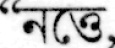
“নত্তে,
